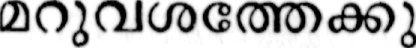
മറുവശത്തേക്കു
